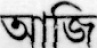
আজি
